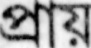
প্রায়
